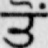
ਤੋਂ
